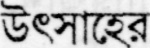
উৎসাহের
